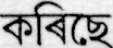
কৰিছে
